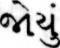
જોયું
